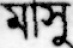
মাসু
